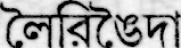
লৈরিঙৈদা
